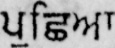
ਪੁਛਿਆ
